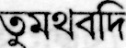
তুমথবদি
